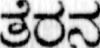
ತೆರನ
